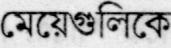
মেয়েগুলিকে
